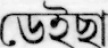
ডেইছা
